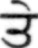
ਤੇ
